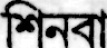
শিনবা
